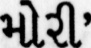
મોરી'
